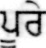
ਪੂਰੇ
